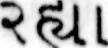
રહ્યા
